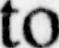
to
